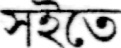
সইতে
